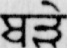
ਬੜੇ
